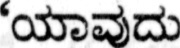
‘ಯಾವುದು
